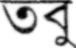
তবু
